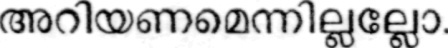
അറിയണമെന്നില്ലല്ലോ.
